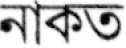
নাকত
